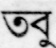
তবু
